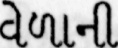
વેળાની
